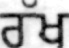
ਰੱਖ
